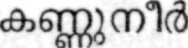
കണ്ണുനീര്‍
